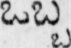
ಒಬ್ಬ
